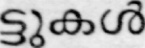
ട്ടുകള്‍
